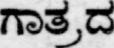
ಗಾತ್ರದ
